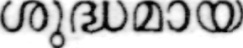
ശുദ്ധമായ
